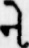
ને
